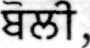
ਬੋਲੀ,
